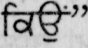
ਕਿਉਂ''
